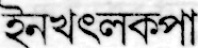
ইনখৎলকপা
